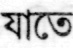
যাতে
